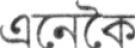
এনেকৈ
